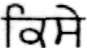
ਕਿਸੇ
